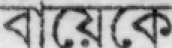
বায়েকে
